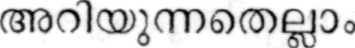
അറിയുന്നതെല്ലാം
